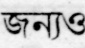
জন্যও
